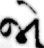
જો
